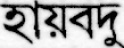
হায়বদু
